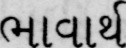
ભાવાર્થ
